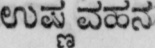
ಉಷ್ಣವಹನ
